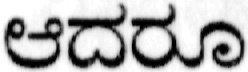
ಆದರೂ
